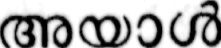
അയാള്‍
